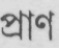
প্ৰাণ
